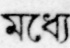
মধ্যে
